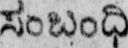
ಸಂಬಂಧಿ
